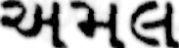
અમલ
